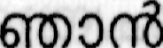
ഞാന്‍
